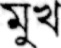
মুখ
